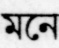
মনে
